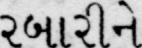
રબારીને
